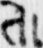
તો
